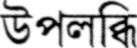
উপলব্ধি
